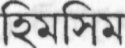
হিমসিম
